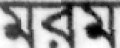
মরম
